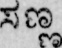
ಸಣ್ಣ
